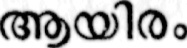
ആയിരം
